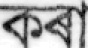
কৰা
